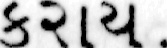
કરાય.
